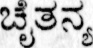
ಚೈತನ್ಯ
